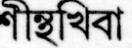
শীন্থখিবা
